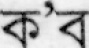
ক'ব
